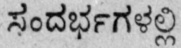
ಸಂದರ್ಭಗಳಲ್ಲಿ
